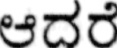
ಆದರೆ
